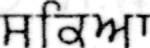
ਸਕਿਆ
